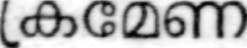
ക്രമേണ
